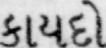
કાયદો
